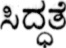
ಸಿದ್ಧತೆ
